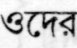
ওদের
